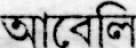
আবেলি
